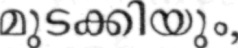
മുടക്കിയും,
